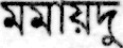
মমায়দু
